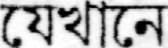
যেখানে
